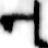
ન
